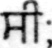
ਸੀ;
